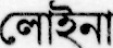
লোইনা
